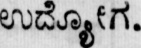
ಉದ್ಯೋಗ.
